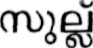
സുല്ല്
